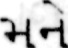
મને
